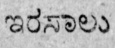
ಇರಸಾಲು
